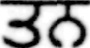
ਤਨ
